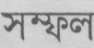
সম্ফল
